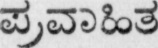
ಪ್ರವಾಹಿತ
